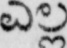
ಎಲ್ಲ
